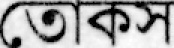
তোকস
